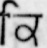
ਕਿ
